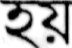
হয়
